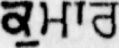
ਕੁਮਾਰ
